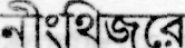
নীংথিজরে
